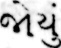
જોયું
